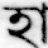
হা
